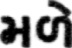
મળે
